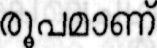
രൂപമാണ്
